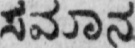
ಸಮಾನ
